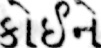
કોઈને
